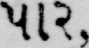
પાર,
